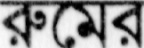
রুমের
